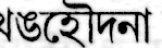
খঙহৌদনা
